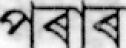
পৰাৰ
